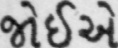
જોઈએ
